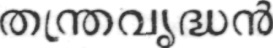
തന്ത്രവൃദ്ധന്‍
